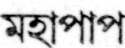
মহাপাপ
